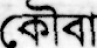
কৌবা
